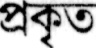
প্রকৃত
